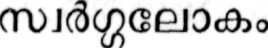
സ്വര്‍ഗ്ഗലോകം
